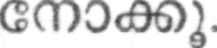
നോക്കൂ.
